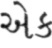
એક
